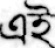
এই
